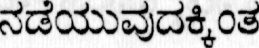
ನಡೆಯುವುದಕ್ಕಿಂತ
